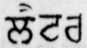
ਲੈਟਰ
